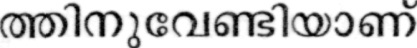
ത്തിനുവേണ്ടിയാണ്
